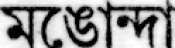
মঙোন্দা
